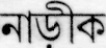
নাড়ীক
